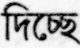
দিচ্ছে
